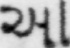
આ
